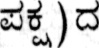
ಪಕ್ಷ)ದ
